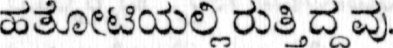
ಹತೋಟಿಯಲ್ಲಿರುತ್ತಿದ್ದವು.
